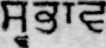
ਸ੍ਵਭਾਵ
